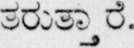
ತರುತ್ತಾರೆ.
